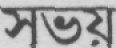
সভয়
